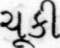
ચૂકી
